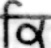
ਕਿ
